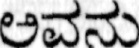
ಅವನು
